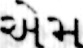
એમ
